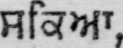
ਸਕਿਆ,
